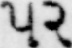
પર
